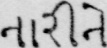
નારીને
